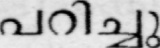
പറിച്ചു
